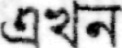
এখন
